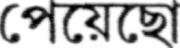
পেয়েছো
